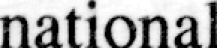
national
